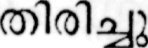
തിരിച്ചു
